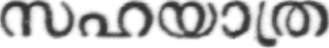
സഹയാത്ര
